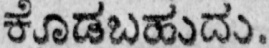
ಕೊಡಬಹುದು.
